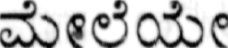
ಮೇಲೆಯೇ
